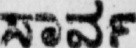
ಸಾರ್ವ
